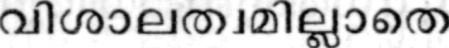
വിശാലത്വമില്ലാതെ
